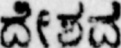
ದೇಶದ
